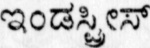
ಇಂಡಸ್ಟ್ರೀಸ್
